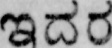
ಇದರ
